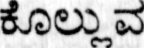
ಕೊಲ್ಲುವ
